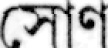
সোণ
